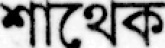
শাথেক
